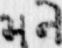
મને
